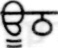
ਊਠ
